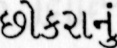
છોકરાનું
